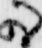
જે
